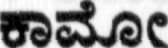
ಕಾಮೋ
